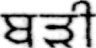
ਬੜੀ
